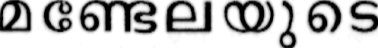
മണ്ടേലയുടെ
